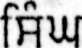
ਸਿੰਘ
